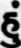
હું
